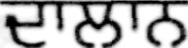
ਦਾਲਾਨ
